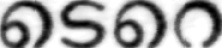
ടെറെ
